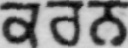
ਕਰਨ
